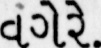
વગેરે.
